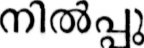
നില്‍പ്പു
